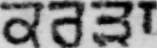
ਕਰੜਾ
